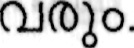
വരും.
